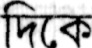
দিকে
